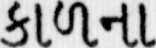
કાળના
